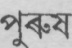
পুৰুষ
